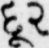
દૂર
